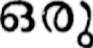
ഒരു
